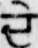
ਦੇ
